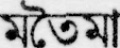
মতৈমা
